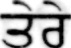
ਤੇਰੇ
